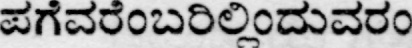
ಪಗೆವರೆಂಬರಿಲ್ಲಿಂದುವರಂ
